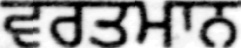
ਵਰਤਮਾਨ
